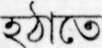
হঠাতে
